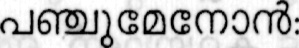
പഞ്ചുമേനോന്‍:
